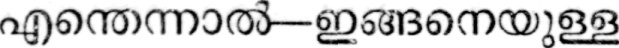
എന്തെന്നാല്‍-ഇങ്ങനെയുള്ള
